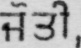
ਜੋਤੀ,
